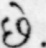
છે.
